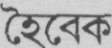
হৈবেক
